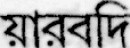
য়ারবদি
